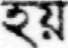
হয়
